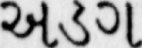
અડગ
